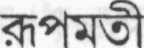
রূপমতী
